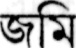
জমি
